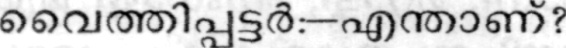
വൈത്തിപ്പട്ടര്‍:-എന്താണ്?
